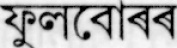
ফুলবোৰৰ
